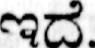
ಇದೆ.
